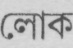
লোক
